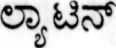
ಲ್ಯಾಟಿನ್
